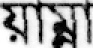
য়াম্না
